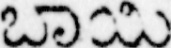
ಬಾಯಿ
